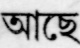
আছে
